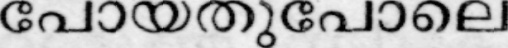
പോയതുപോലെ
